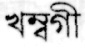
খম্বগী
